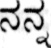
ನನ್ನ
